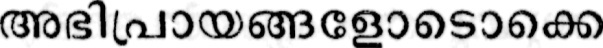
അഭിപ്രായങ്ങളോടൊക്കെ
